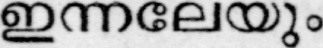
ഇന്നലേയും
